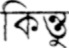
কিন্তু
